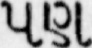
પણ
